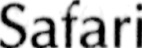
Safari
